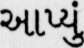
આપ્યું
